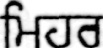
ਮਿਹਰ
